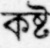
কষ্ট
